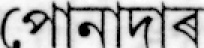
পোনাদাৰ
